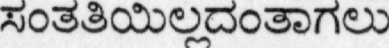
ಸಂತತಿಯಿಲ್ಲದಂತಾಗಲು
